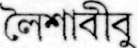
লৈশাবীদু
